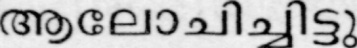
ആലോചിച്ചിട്ടു
